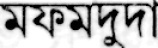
মফমদুদা
